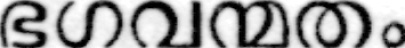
ഭഗവന്മതം
